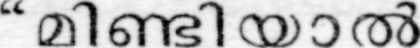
"മിണ്ടിയാല്‍
